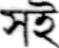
সই
